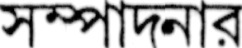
সম্পাদনার
